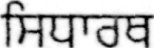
ਸਿਧਾਰਥ
